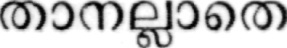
താനല്ലാതെ
